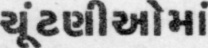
ચૂંટણીઓમાં
